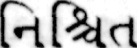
નિશ્ચિત
